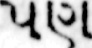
પણ
